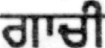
ਗਾਚੀ
